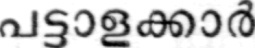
പട്ടാളക്കാര്‍
